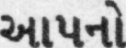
આપનો
